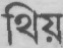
থিয়
